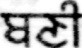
ਬਣੀ
